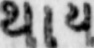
થાય
